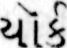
યૉર્ક
